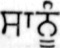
ਸਾਨੂੰ
